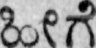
ಹೀಗೆ
